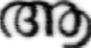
ആ
